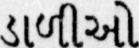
ડાળીઓ
